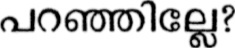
പറഞ്ഞില്ലേ?
